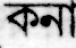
কনা
